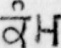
ਕੰਮ
